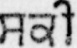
ਸਕੀ
